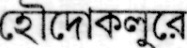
হৌদোকলুরে
